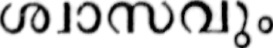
ശ്വാസവും
